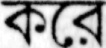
করে
